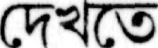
দেখতে
